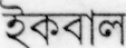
ইকবাল
